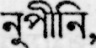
নুপীনি,
